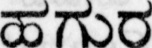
ಹಗುರ
